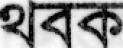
থবক
